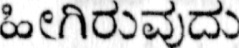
ಹೀಗಿರುವುದು
